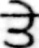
ਤੇ
